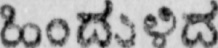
ಹಿಂದುಳಿದ
